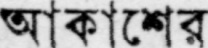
আকাশের
